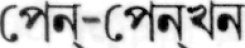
পেন্‌-পেন্‌খন
